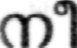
നീ
